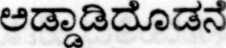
ಅಡ್ಡಾಡಿದೊಡನೆ
